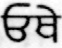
ਓਥੇ
